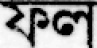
ফল
